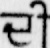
ਦੀ
